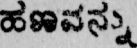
ಹಣವನ್ನು
